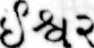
ઇશ્વર
